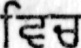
ਵਿਚ
